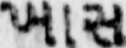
ખાસ
